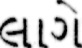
લાગે
